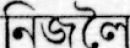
নিজলৈ
